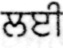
ਲਈ
